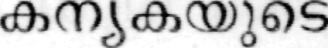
കന്യകയുടെ
